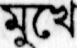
মুখে
